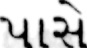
પાસે
